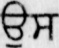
ਉਸ
